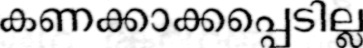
കണക്കാക്കപ്പെടില്ല
